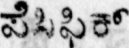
ಪೆಸಿಫಿಕ್
